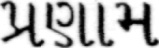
પ્રણામ
